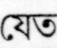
যেত
